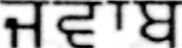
ਜਵਾਬ
